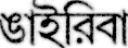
ঙাইরিবা
